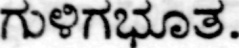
ಗುಳಿಗಭೂತ.
